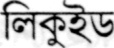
লিকুইড
